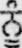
ਨੂੰ
